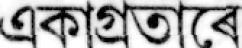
একাগ্রতাৰে
